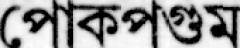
পোকপগুম
